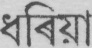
ধৰিয়া
